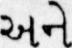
અને
